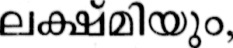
ലക്ഷ്മിയും,
